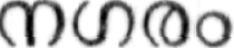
നഗരം
